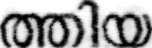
ത്തിയ
